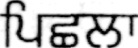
ਪਿਛਲਾ
